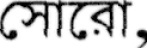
সোরো,
